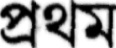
প্রথম
